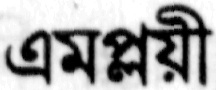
এমপ্লয়ী
